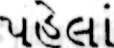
પહેલાં
